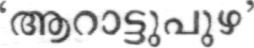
‘ആറാട്ടുപുഴ’
